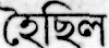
হৈছিল
